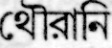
থৌরানি
